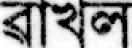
ৱাখল
